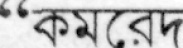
“কমরেদ
